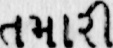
તમારી
